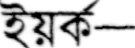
ইয়র্ক–
